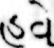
હવે
